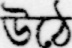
উঠে
